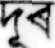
দূৰ
